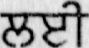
ਲਈ
